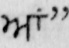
ਆਂ''
